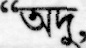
“অদু,
